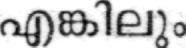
എങ്കിലും
